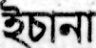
ইচানা
